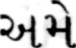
અમે
